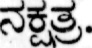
ನಕ್ಷತ್ರ.
